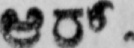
ಆರ್.
